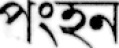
পংহন
